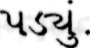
પડ્યું.
